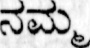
ನಮ್ಮ
